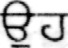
ਉਹ
